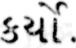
કર્યો.
